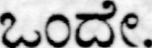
ಒಂದೇ.
